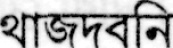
থাজদবনি
